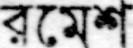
রমেশ
